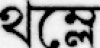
থম্লে
